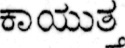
ಕಾಯುತ್ತ
